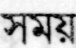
সময়
